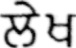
ਲੇਖ
